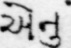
એનું
